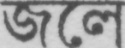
জলে
